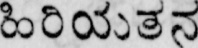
ಹಿರಿಯತನ
